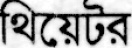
থিয়েটর
